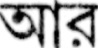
আর
